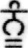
ਨੂੰ
